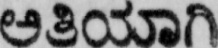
ಅತಿಯಾಗಿ
